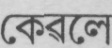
কেৱলে
